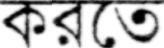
করতে
